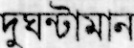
দুঘন্টামান
